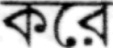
করে
